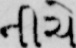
નીચે
